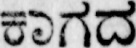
ಕಾಗದ
